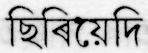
ছিৰিয়েদি
